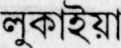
লুকাইয়া
